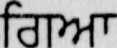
ਗਿਆ
